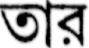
তার
